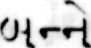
બન્ને
